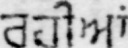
ਰਹੀਆਂ
